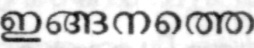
ഇങ്ങനത്തെ
